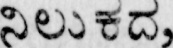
ನಿಲುಕದ,
